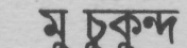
মুচুকুন্দ
